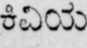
ಕಿವಿಯ
